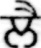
ਲੈ
